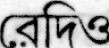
রেদিও
